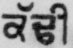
ਕੱਢੀ
